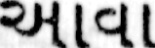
આવા
